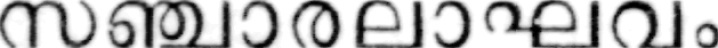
സഞ്ചാരലാഘവം
